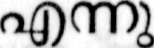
എന്നു
